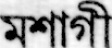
মশাগী
